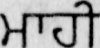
ਮਾਹੀ
